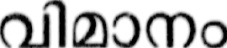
വിമാനം
